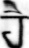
ਹੈ
